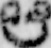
ಆ
